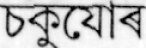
চকুযোৰ
